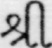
શ્રી
